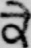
ਕੇ
